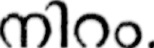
നിറം.
